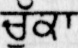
ਚੁੱਕਾ
